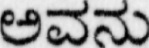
ಅವನು
